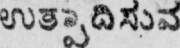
ಉತ್ಪಾದಿಸುವ
